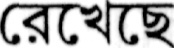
রেখেছে
